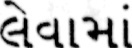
લેવામાં
